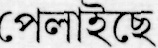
পেলাইছে
